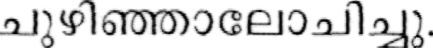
ചുഴിഞ്ഞാലോചിച്ചു.
